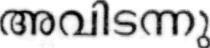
അവിടന്നു
